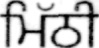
ਮਿੱਠੀ
